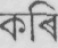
কৰি
